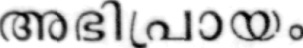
അഭിപ്രായം
